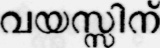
വയസ്സിന്
